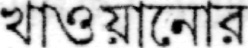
খাওয়ানোর
